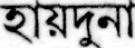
হায়দুনা
